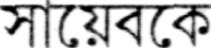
সায়েবকে
